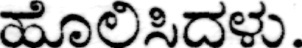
ಹೊಲಿಸಿದಳು.
